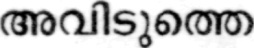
അവിടുത്തെ
